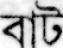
বাট
